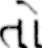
તો
